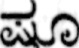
ಷೂ
